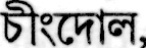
চীংদোল,
